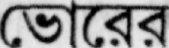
ভোরের
